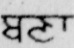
ਬਣਾ
